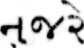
નજરે
